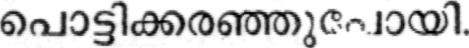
പൊട്ടിക്കരഞ്ഞുപോയി.
